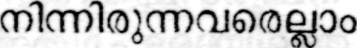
നിന്നിരുന്നവരെല്ലാം
